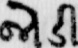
જોડી
